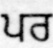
ਪਰ
